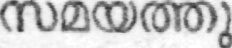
സമയത്തു
